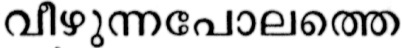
വീഴുന്നപോലത്തെ
